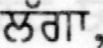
ਲੱਗਾ,
